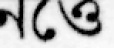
নত্তে
